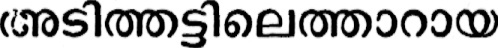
അടിത്തട്ടിലെത്താറായ
